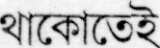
থাকোতেই
